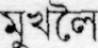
মুখলৈ
